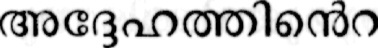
അദ്ദേഹത്തിന്റെ
